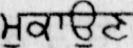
ਮੁਕਾਉਣ
